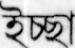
ইচ্ছা
